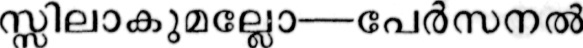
സ്സിലാകുമല്ലോ-പേര്‍സനല്‍
